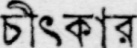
চীৎকার
